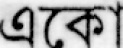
একো
